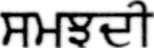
ਸਮਝਦੀ
